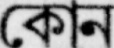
কোন
